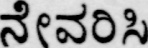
ನೇವರಿಸಿ
